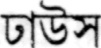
ঢাউস
